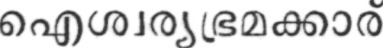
ഐശ്വര്യഭ്രമക്കാര്
